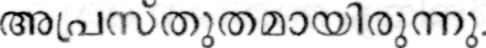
അപ്രസ്തുതമായിരുന്നു.
